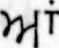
ਆਂ
